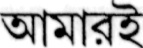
আমারই
